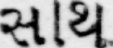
સાથ
